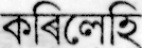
কৰিলেহি
